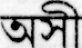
অসী
